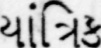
યાંત્રિક
